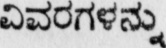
ವಿವರಗಳನ್ನು
